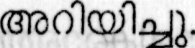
അറിയിച്ചു.
